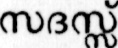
സദസ്സ്
